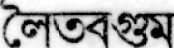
লৈতবগুম
